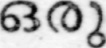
ഒരു
